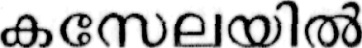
കസേലയില്‍
